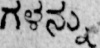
ಗಳನ್ನು
